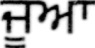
ਜੂਆ
